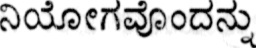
ನಿಯೋಗವೊಂದನ್ನು
